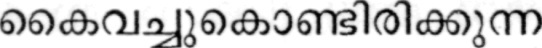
കൈവച്ചുകൊണ്ടിരിക്കുന്ന
